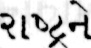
રાષ્ટ્રને
